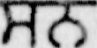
ਸਨ
